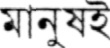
মানুষই
